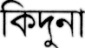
কিদুনা
